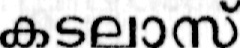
കടലാസ്
